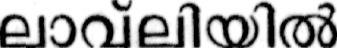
ലാവ്ലിയില്‍
